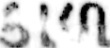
કાળ
